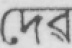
দেৱ
